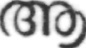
ആ
